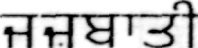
ਜਜ਼ਬਾਤੀ
